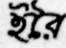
ইরৈ
